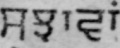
ਸਝਾਵਾਂ
